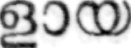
ളായ
